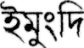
ইমুংদি
